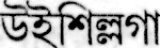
উইশিল্লগা
